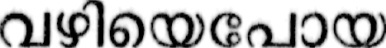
വഴിയെപോയ
